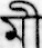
মী
